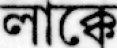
লাক্কে
